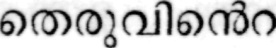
തെരുവിന്റെ
